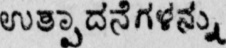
ಉತ್ಪಾದನೆಗಳನ್ನು
